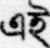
এই
